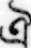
ঐ
